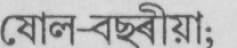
ষোল-বছৰীয়া;
